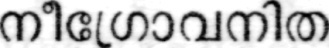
നീഗ്രോവനിത
